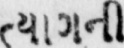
ત્યાગની
